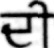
ਦੀ
